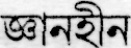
জ্ঞানহীন
